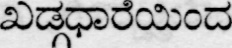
ಖಡ್ಗಧಾರೆಯಿಂದ
